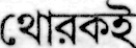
থোরকই
